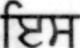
ਇਸ
